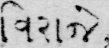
વિરાજે,
